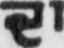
ਦਾ
